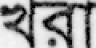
খরা
